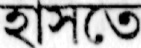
হাসতে
